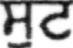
ਸੁਟ
